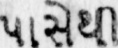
પાસેથી
